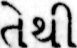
તેથી
